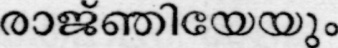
രാജ്ഞിയേയും
